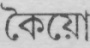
কৈয়ো
